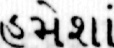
હમેશાં
